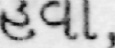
હવા,
